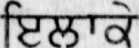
ਇਲਾਕੇ
